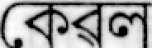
কেৱল
